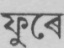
ফুৰে
